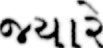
જ્યારે
